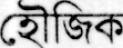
হৌজিক
